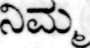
ನಿಮ್ಮ
